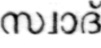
സ്വാദ്
